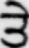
ਤੇ
